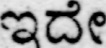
ಇದೇ
